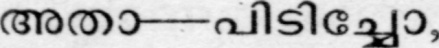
അതാ-പിടിച്ചോ,
